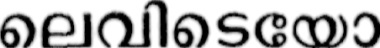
ലെവിടെയോ
